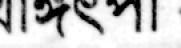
থাঙ্গৎপা
